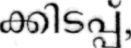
ക്കിടപ്പ്,
